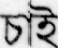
চাই
